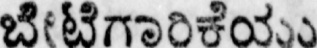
ಬೇಟೆಗಾರಿಕೆಯು
